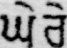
ਘੇਰੇ
